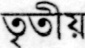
তৃতীয়
